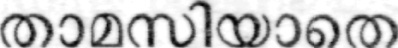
താമസിയാതെ
